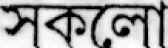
সকলো
